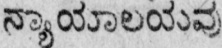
ನ್ಯಾಯಾಲಯವು
